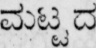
ಮಟ್ಟದ
